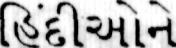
હિંદીઓને
